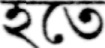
হতে
